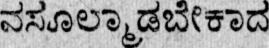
ವಸೂಲ್ಮಾಡಬೇಕಾದ
